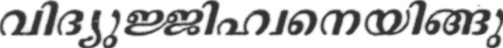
വിദ്യുജ്ജിഹ്വനെയിങ്ങു
